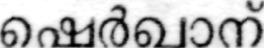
ഷെര്‍ഖാന്
